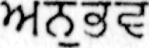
ਅਨੁਭਵ
